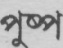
পুষ্প
